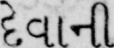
દેવાની
